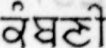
ਕੰਬਣੀ
